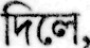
দিলে,
